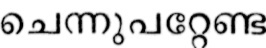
ചെന്നുപറ്റേണ്ട
